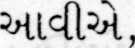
આવીએ,
